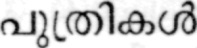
പുത്രികള്‍
